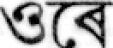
ওৰে
